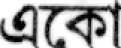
একো
